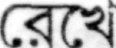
রেখে
